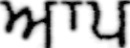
ਆਪ
